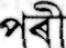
পৰী
